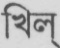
খিল্‌
